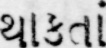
થાકતાં
